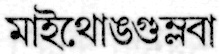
মাইথোঙগুম্লবা
